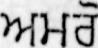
ਅਮਰੋ
